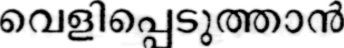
വെളിപ്പെടുത്താന്‍
